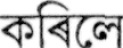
কৰিলে
